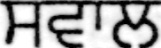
ਸਵਾਲ
